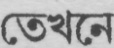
তেখনে
